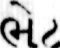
ભેટ
